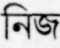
নিজ
